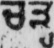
ਚੜ੍ਹ
